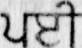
ਪਈ
